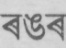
ৰঙৰ
